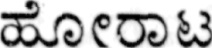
ಹೋರಾಟ
